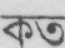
কত
